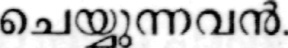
ചെയ്യുന്നവന്‍.
